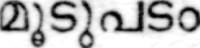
മൂടുപടം
